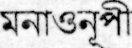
মনাওনূপী
